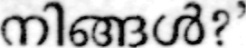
നിങ്ങള്‍?’
